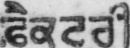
ਫ਼ੈਕਟਰੀ
